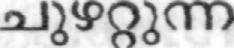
ചുഴറ്റുന്ന
